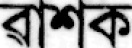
ৱাশক
